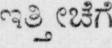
ಇತ್ತೀಚೆಗೆ
